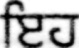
ਇਹ
